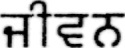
ਜੀਵਨ
